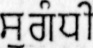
ਸੁਗੰਧੀ
